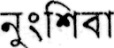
নুংশিবা
